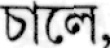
চালে,
